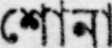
শোনা
